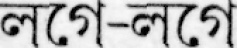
লগে-লগে
